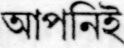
আপনিই
